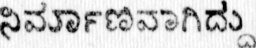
ನಿರ್ಮಾಣವಾಗಿದ್ದು
